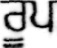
ਰੂਪ
